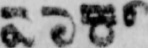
ವಾಕ್
